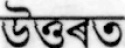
উত্তৰত
